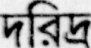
দরিদ্র
